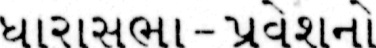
ધારાસભા-પ્રવેશનો
